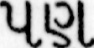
પણ
